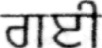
ਗਈ
